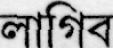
লাগিব
